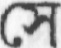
সে
